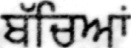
ਬੱਚਿਆਂ
